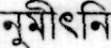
নুমীৎনি
